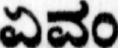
ಏವಂ
